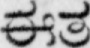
ಈತ
